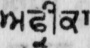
ਅਫ੍ਰੀਕਾ
